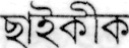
ছাইকীক
